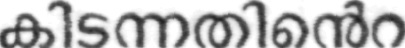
കിടന്നതിന്റെ
